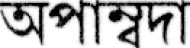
অপাম্বদা
